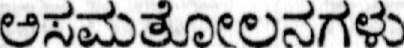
ಅಸಮತೋಲನಗಳು
